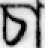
চা
